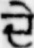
ਦੇ
